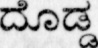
ದೊಡ್ಡ
